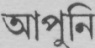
আপুনি
